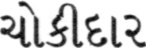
ચોકીદાર
